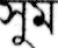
সুম
